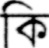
কি
